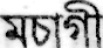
মচাগী
